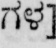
ಗಳ]
